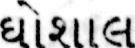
ઘોશાલ
